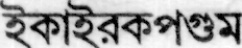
ইকাইরকপগুম
